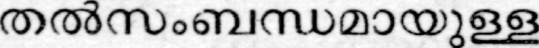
തല്‍സംബന്ധമായുള്ള
